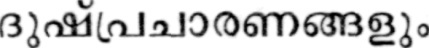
ദുഷ്പ്രചാരണങ്ങളും
